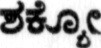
ಶಕ್ಯೋ
